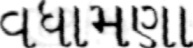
વધામણા
